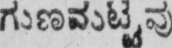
ಗುಣಮಟ್ಟವು
